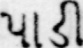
પાડી
